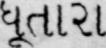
ધૂતારા
